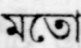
মতো
